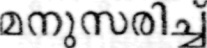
മനുസരിച്ച്
